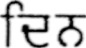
ਦਿਨ
